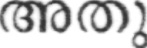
അതു
